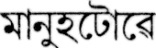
মানুহটোৱে
